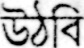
উঠবি
